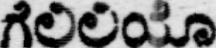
ಗೆಲಿಲಿಯೊ
